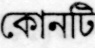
কোনটি
